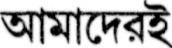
আমাদেরই
